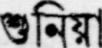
শুনিয়া
